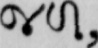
જળ,
